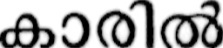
കാരില്‍
